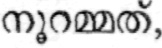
നൂറമ്മത്,
